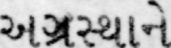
અગ્રસ્થાને
